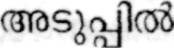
അടുപ്പില്‍
